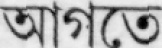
আগতে
